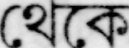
থেকে
